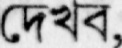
দেখব,
